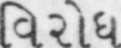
વિરોધ
